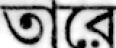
তারে
